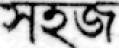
সহজ
